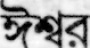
ঈশ্বর
